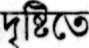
দৃষ্টিতে
